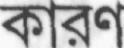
কারণ
